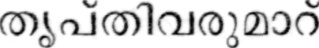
തൃപ്തിവരുമാറ്
